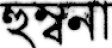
হুম্বনা
